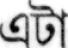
এটা
